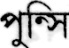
পুন্সি
